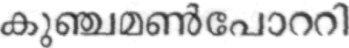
കുഞ്ചമണ്‍പോററി
